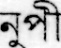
নুপী
